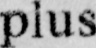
plus
